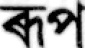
ৰূপ
